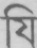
যি
